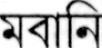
মবানি
